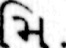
મિ.
